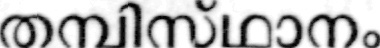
തമ്പിസ്ഥാനം
